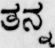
ತನ್ನ
